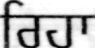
ਰਿਹਾ
